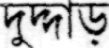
দুদ্দাড়
